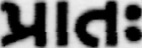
પ્રાતઃ
